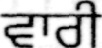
ਵਾਰੀ
